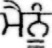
ਮੈਨੂੰ
